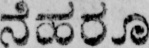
ನೆಹರೂ
